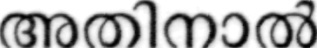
അതിനാല്‍
